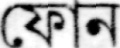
ফোন
